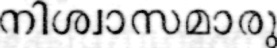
നിശ്വാസമാരു
